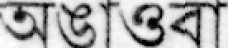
অঙাওবা
